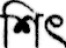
শিৎ
